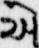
એ
